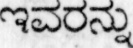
ಇವರನ್ನು
